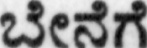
ಬೇನೆಗೆ
